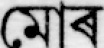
মোৰ
